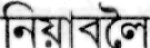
নিয়াবলৈ
